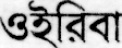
ওইরিবা
